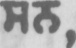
ਸਨ,
